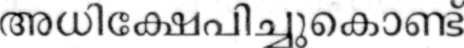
അധിക്ഷേപിച്ചുകൊണ്ട്
